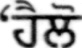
'ਹੈਲੋ
